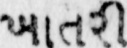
ખાતરી
